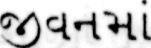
જીવનમાં
